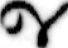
જ
